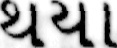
થયા
